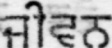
ਜੀਵਨ
